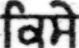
ਕਿਸੇ
